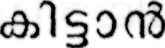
കിട്ടാന്‍
